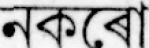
নকৰো
